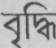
বৃদ্ধি
